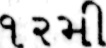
૧૨મી
